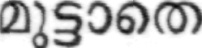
മുട്ടാതെ
